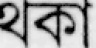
থকা
